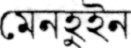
মেনহুইন
